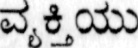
ವ್ಯಕ್ತಿಯು
